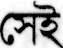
সেই
